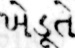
ખેડૂતે
